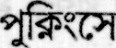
পুক্নিংসে
